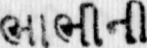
ભાભીની
